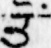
ਤੋਂ
